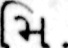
મિ.
